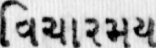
વિચારમય
